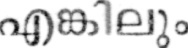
എങ്കിലും
